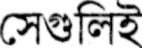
সেগুলিই
